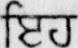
ਇਹ
